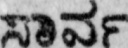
ಸಾರ್ವ
